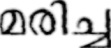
മരിച്ച
